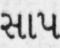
સાપ
